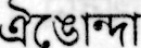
ঐঙোন্দা
